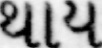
થાય
